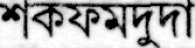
শকফমদুদা
